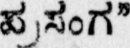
ಪ್ರಸಂಗ”
